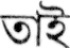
তাই
